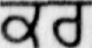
ਕਰ
